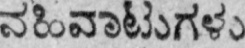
ವಹಿವಾಟುಗಳು
